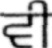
ਵੀ
